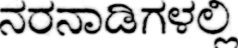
ನರನಾಡಿಗಳಲ್ಲಿ
